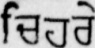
ਚਿਹਰੇ
